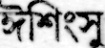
ঈশিংসু
